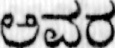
ಅವರ
